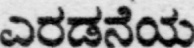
ಎರಡನೆಯ
